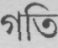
গতি
